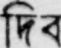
দিব
